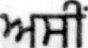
ਅਸੀਂ
